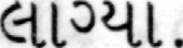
લાગ્યા.
